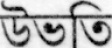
উভতি
